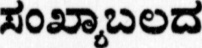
ಸಂಖ್ಯಾಬಲದ
